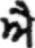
ਐ
